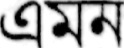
এমন
